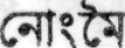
নোংমৈ
